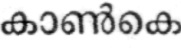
കാണ്‍കെ
